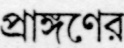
প্রাঙ্গণের
